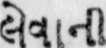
લેવાની
